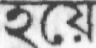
হয়ে
